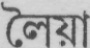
লৈয়া
